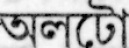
অলটো
